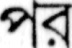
পর
